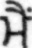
ਮੈਂ
